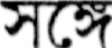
সঙ্গে
